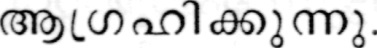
ആഗ്രഹിക്കുന്നു.
